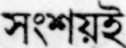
সংশয়ই
